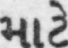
માટે
